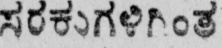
ಸರಕುಗಳಿಗಿಂತ
